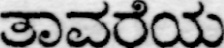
ತಾವರೆಯ
